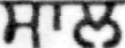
ਸਾਲ
